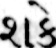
શકે
